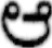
ಆ
